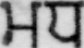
ਮਧ
